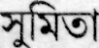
সুমিতা
